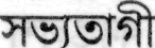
সভ্যতাগী
